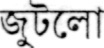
জুটলো
